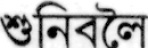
শুনিবলৈ
